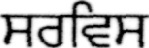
ਸਰਵਿਸ
